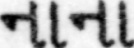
નાના
